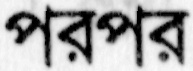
পরপর
